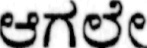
ಆಗಲೇ
